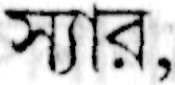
স্যার,
